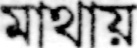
মাথায়
